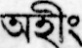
অহীং
